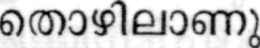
തൊഴിലാണു
